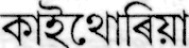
কাইথোৰিয়া
